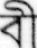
বী
